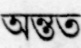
অন্তত
